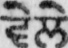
ਵੇਲੇ
